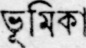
ভূমিকা
